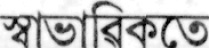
স্বাভাৱিকতে
